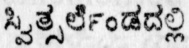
ಸ್ವಿತ್ಸರ್ಲೆಂಡದಲ್ಲಿ
